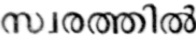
സ്വരത്തില്‍
